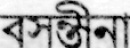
বসন্তীনা
